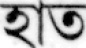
হাত
